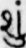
શું
